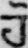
ਹੋ
